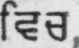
ਵਿਚ,
